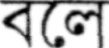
বলে
